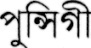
পুন্সিগী
